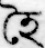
হৈ
